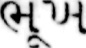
ભૂખ
